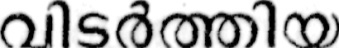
വിടര്‍ത്തിയ
